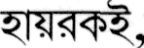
হায়রকই,
